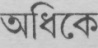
অধিকে
